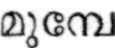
മുമ്പേ
